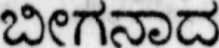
ಬೀಗನಾದ
